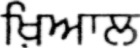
ਖ਼ਿਆਲ
